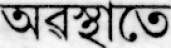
অৱস্হাতে
